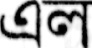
এল
